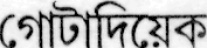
গোটাদিয়েক
